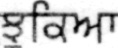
ਝੁਕਿਆ
